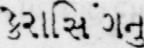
કેરાસિંગનુ
